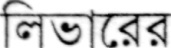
লিভারের
